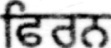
ਫਿਰਨ
